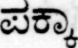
ಪಕ್ಕಾ
